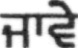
ਜਾਵੇ
